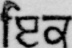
ਇਕ
